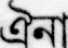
ঐনা
